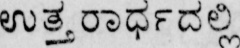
ಉತ್ತರಾರ್ಧದಲ್ಲಿ
